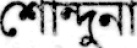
শোন্দুনা
